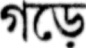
গড়ে
